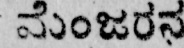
ಮೆಂಜರನ
